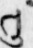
તું
